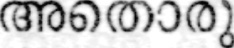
അതൊരു
